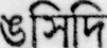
ঙসিদি
